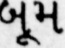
બૂમ
